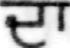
ਦਾ
